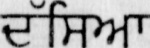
ਦੱਸਿਆ
